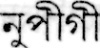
নুপীগী
